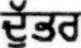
ਦੁੱਭਰ
